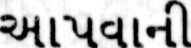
આપવાની
